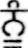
ਨੂੰ
